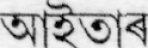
আইতাৰ
